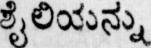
ಶೈಲಿಯನ್ನು
